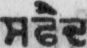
ਸਫੈਦ
